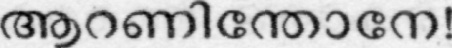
ആറണിന്തോനേ!
